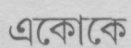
একোকে
